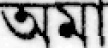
অমা
